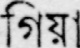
গিয়া
